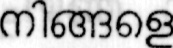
നിങ്ങളെ
